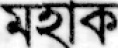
মহাক
